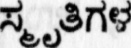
ಸ್ಮೃತಿಗಳ
